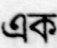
এক
